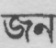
জন
